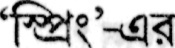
‘স্প্রিং’-এর
